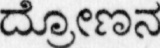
ದ್ರೋಣನ
